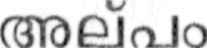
അല്പം
